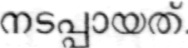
നടപ്പായത്.
